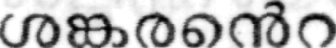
ശങ്കരന്റെ
